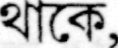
থাকে,
